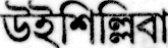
উইশিল্লিবা
